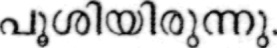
പൂശിയിരുന്നു.
